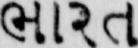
ભારત
